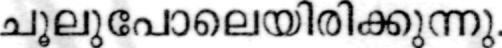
ചൂലുപോലെയിരിക്കുന്നു.
